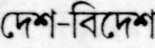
দেশ-বিদেশ
